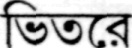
ভিতরে
